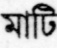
মাটি
